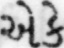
એકે
